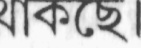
থাকছে
